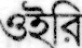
ওইরি
